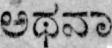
ಅಥವಾ
